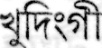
খুদিংগী
